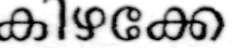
കിഴക്കേ
